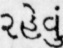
રહેવું
